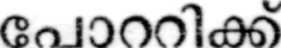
പോററിക്ക്
